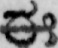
ಈ
